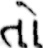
તો
